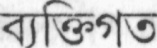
ব্যক্তিগত
